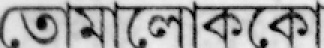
তোমালোককো
